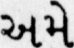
અમે
